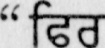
''ਫਿਰ
